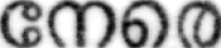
നേരെ
